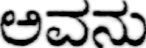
ಅವನು
